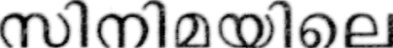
സിനിമയിലെ
